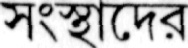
সংস্থাদের
